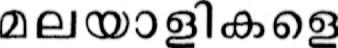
മലയാളികളെ
